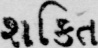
શક્તિ
